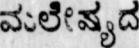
ಮಲೇಷ್ಯದ
